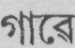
গাৱে
